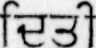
ਦਿਤੀ
